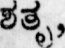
ಶತೃ,
